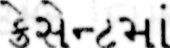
ક્રેસેન્ટમાં
